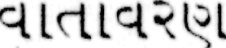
વાતાવરણ
